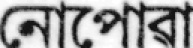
নোপোৱা
